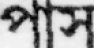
পাস
